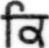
ਕਿ
